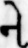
ને
